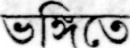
ভঙ্গিতে
